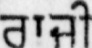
ਰਾਜੀ
